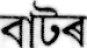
বাটৰ
